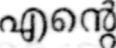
എന്റെ
